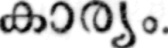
കാര്യം.
